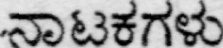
ನಾಟಕಗಳು
